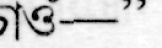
চাওঁ-"
